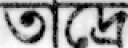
তাদ্রে
